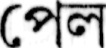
পেল
